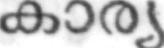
കാര്യ
